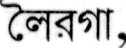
লৈরগা,
